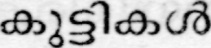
കുട്ടികള്‍
